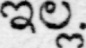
ಇಲ್ಲ.
